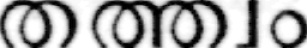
തത്ത്വം
